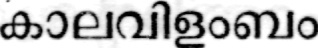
കാലവിളംബം
